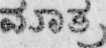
ಮಾತ್ರ
